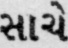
સાચે
